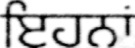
ਇਹਨਾਂ
